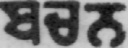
ਬਚਨ
